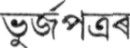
ভুর্জপত্রৰ
